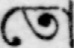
তো
